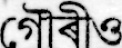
গৌৰীও
